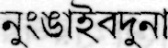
নুংঙাইবদুনা
